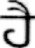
ਹੈ
